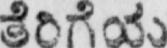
ತೆರಿಗೆಯ
